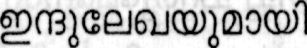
ഇന്ദുലേഖയുമായി
